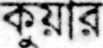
কুয়ার
